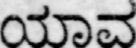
ಯಾವ
